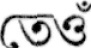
তেওঁ
